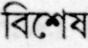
বিশেষ
